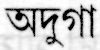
অদুগা
